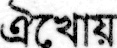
ঐখোয়
